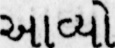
આવ્યો
